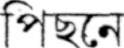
পিছনে
